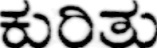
ಕುರಿತು
